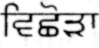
ਵਿਛੋੜਾ
